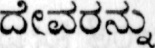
ದೇವರನ್ನು
